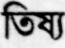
তিষ্য
